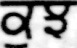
ਕੁਝ
